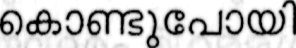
കൊണ്ടുപോയി
